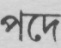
পদে
